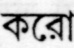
করো
